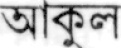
আকুল
